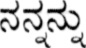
ನನ್ನನ್ನು
